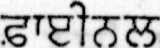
ਫ਼ਾਈਨਲ
